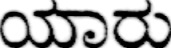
ಯಾರು
